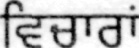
ਵਿਚਾਰਾਂ
